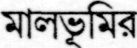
মালভূমির
